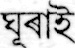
ঘূৰাই
